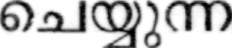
ചെയ്യുന്ന
